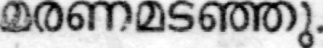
മരണമടഞ്ഞു.
